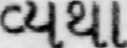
વ્યથા
